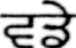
ਵਡੇ
